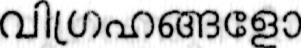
വിഗ്രഹങ്ങളോ
